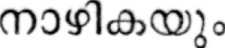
നാഴികയും
